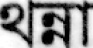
থন্না
